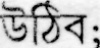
উঠিব;
